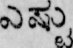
ಎಷ್ಟು
